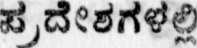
ಪ್ರದೇಶಗಳಲ್ಲಿ
